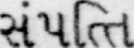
સંપત્તિ
